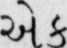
એક
